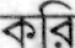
করি
